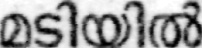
മടിയില്‍
